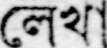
লেখা
